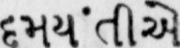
દમયંતીએ
